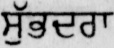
ਸੁੱਭਦਰਾ
